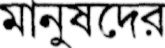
মানুষদের
